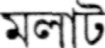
মলাট
